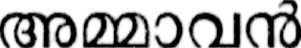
അമ്മാവന്‍
